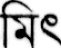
মিৎ
